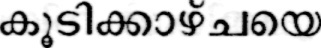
കൂടിക്കാഴ്ചയെ
